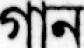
গান
